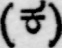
(ಕ)
